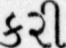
કરી
